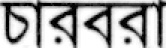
চারবরা
